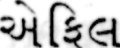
એફિલ
